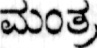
ಮಂತ್ರ
